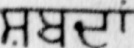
ਸ਼ਬਦਾਂ
